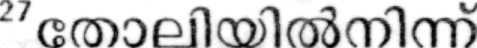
27തോലിയില്‍നിന്ന്
